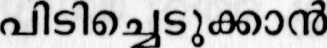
പിടിച്ചെടുക്കാന്‍
